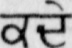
ਕਦੇ
